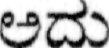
ಅದು
